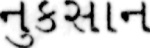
નુકસાન
